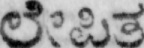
ಲೇಪಿತ
